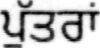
ਪੁੱਤਰਾਂ
